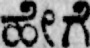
ಹೇಗೆ
